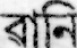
ৱানি
